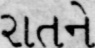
રાતને
